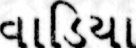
વાડિયા
